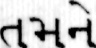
તમને
